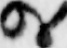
જ
